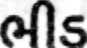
ભીડ
